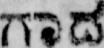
ಗಾದ
